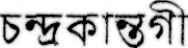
চন্দ্রকান্তগী
